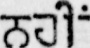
ਨਹੀਂ
